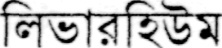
লিভারহিউম
